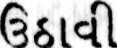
ઉઠાવી
